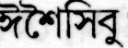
ঈশৈসিবু
